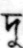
দু
